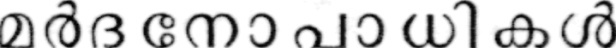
മര്‍ദനോപാധികള്‍
